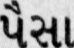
પૈસા
